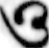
ও
